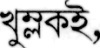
খুম্লকই,
